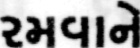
રમવાને
